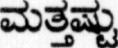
ಮತ್ತಷ್ಟು
